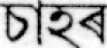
চাহৰ
